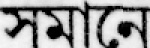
সমানে
